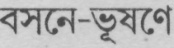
বসনে-ভূষণে
